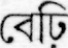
বেঢ়ি
